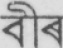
বীৰ
